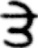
ਤੇ
